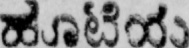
ಹೂಟೆಯ
